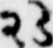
રડે
